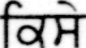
ਕਿਸੇ
